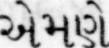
એમણે
